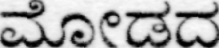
ಮೋಡದ
